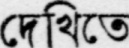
দেখিতে
